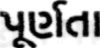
પૂર્ણતા
